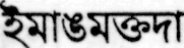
ইমাঙমক্তদা
